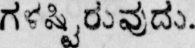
ಗಳಷ್ಟಿರುವುದು.
